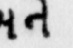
અને
